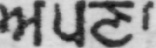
ਅਪਣਾ
